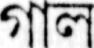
গাল
